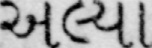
અલ્યા
